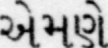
એમણે
